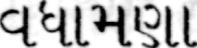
વધામણા
